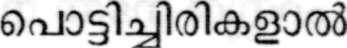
പൊട്ടിച്ചിരികളാല്‍
